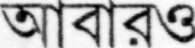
আবারও
